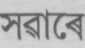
সৱাৰে
